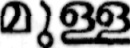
മുള്ള
